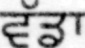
ਵੱਡਾ
